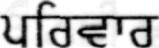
ਪਰਿਵਾਰ
